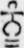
ਨੂੰ
